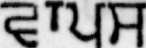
ਵਾਪਸ
